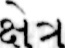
ક્ષેત્ર
